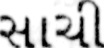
સાચી
